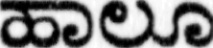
ಹಾಲೂ
